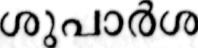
ശുപാര്‍ശ
